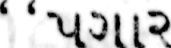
"પગાર
